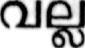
വല്ല
